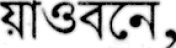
য়াওবনে,
